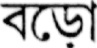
বড়ো
